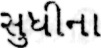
સુધીના
